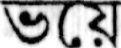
ভয়ে
